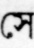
সে
